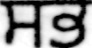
ਸਭ
